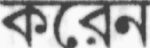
করেন
